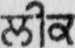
ਲੀਕ
